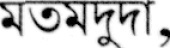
মতমদুদা,
